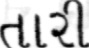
તારી
